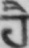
ਹੈ
